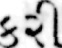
કરી
